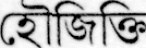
হৌজিক্তি
